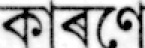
কাৰণে
